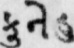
કુનેહ
